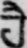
ਹੈ
